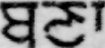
ਬਣਾ
